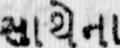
સાથેના
